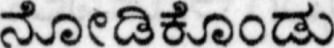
ನೋಡಿಕೊಂಡು
